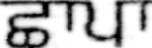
ਛਾਪਾ
